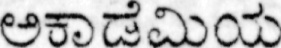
ಅಕಾಡೆಮಿಯ
